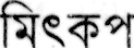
মিৎকপ
